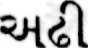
અઢી
